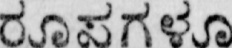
ರೂಪಗಳೂ
